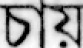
চায়
